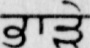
ਭਾੜੇ
